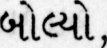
બોલ્યો,
